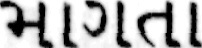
માગતા
